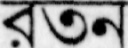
রতন
